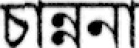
চান্ননা
